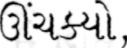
ઊંચક્યો,
